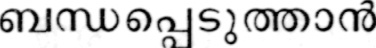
ബന്ധപ്പെടുത്താന്‍
